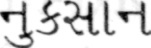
નુકસાન
